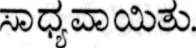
ಸಾಧ್ಯವಾಯಿತು.
